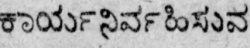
ಕಾರ್ಯನಿರ್ವಹಿಸುವ
